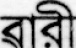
ৱারী
